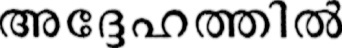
അദ്ദേഹത്തില്‍
